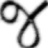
જ
